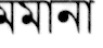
মমানা
